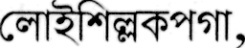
লোইশিল্লকপগা,
